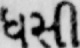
ધસી
